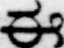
ಈ
